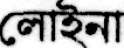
লোইনা
